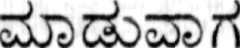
ಮಾಡುವಾಗ
